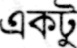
একটু
